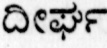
ದೀರ್ಘ
